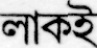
লাকই
